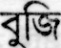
বুজি
